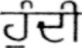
ਹੁੰਦੀ
